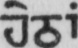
ਹੇਠਾਂ
